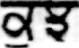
ਕੁਝ
